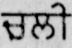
ਚਲੀ
